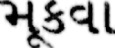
મૂકવા
